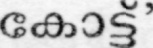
കോട്ട്'
